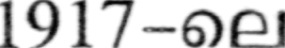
1917-ലെ
